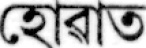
হোৱাত
